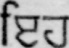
ਇਹ
